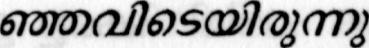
ഞ്ഞവിടെയിരുന്നു
